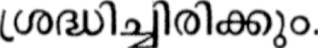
ശ്രദ്ധിച്ചിരിക്കും.
